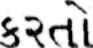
કરતો
